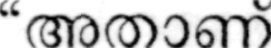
"അതാണ്
